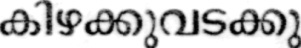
കിഴക്കുവടക്കു
